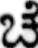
ಚೆ
